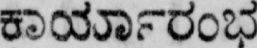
ಕಾರ್ಯಾರಂಭ
